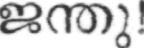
ജന്തു!
